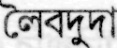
লৈবদুদা
